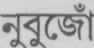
নুবুজোঁ
